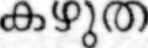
കഴുത
